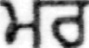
ਮਰ
